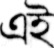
এই
